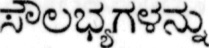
ಸೌಲಭ್ಯಗಳನ್ನು
